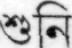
শুনি
